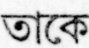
তাকে
